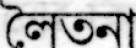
লৈতনা
